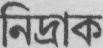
নিদ্ৰাক
